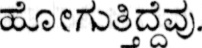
ಹೋಗುತ್ತಿದ್ದೆವು.
